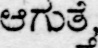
ಆಗುತ್ತೆ,
